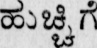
ಹುಚ್ಚಿಗೆ
